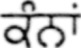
ਕੰਨਾਂ
